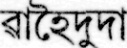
ৱাহৈদুদা
